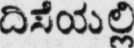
ದಿಸೆಯಲ್ಲಿ
